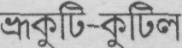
ভ্ৰূকুটি-কুটিল
